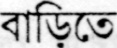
বাড়িতে
